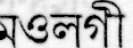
মওলগী
